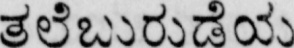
ತಲೆಬುರುಡೆಯ
